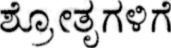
ಶ್ರೋತೃಗಳಿಗೆ
